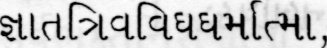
જ્ઞાતત્રિવવિઘઘર્માત્મા,
